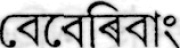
বেবেৰিবাং
